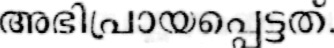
അഭിപ്രായപ്പെട്ടത്.
